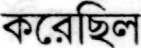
করেছিল
